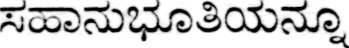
ಸಹಾನುಭೂತಿಯನ್ನೂ
